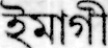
ইমাগী
